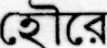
হৌরে
